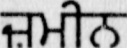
ਜ਼ਮੀਨ
